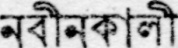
নবীনকালী
